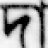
দা
